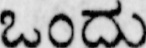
ಒಂದು
